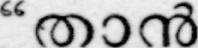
"താന്‍
